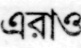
এরাও
